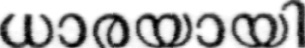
ധാരയായി
